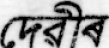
দেৱীৰ
